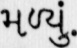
મળ્યું.
